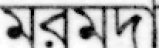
মরমদা
